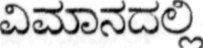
ವಿಮಾನದಲ್ಲಿ
